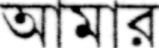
আমার
